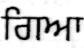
ਗਿਆ
